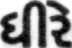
ધીરે
